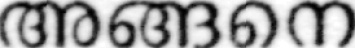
അങ്ങനെ
